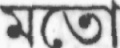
মতো
